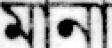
মানা
